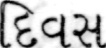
દિવસ
